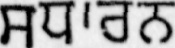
ਸਧਾਰਨ
